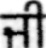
ਜੀ
